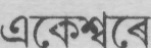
একেশ্বৰে
